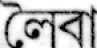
লৈবা
